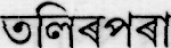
তলিৰপৰা
